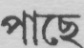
পাছে
